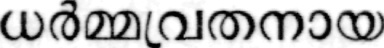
ധര്‍മ്മവ്രതനായ
